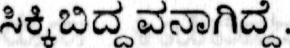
ಸಿಕ್ಕಿಬಿದ್ದವನಾಗಿದ್ದೆ.
